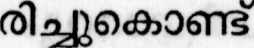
രിച്ചുകൊണ്ട്
